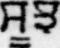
ਸੂਝ
